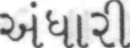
અંધારી
